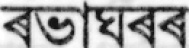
ৰভাঘৰৰ
